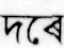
দৰে
